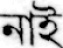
নাই
